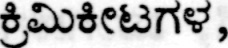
ಕ್ರಿಮಿಕೀಟಗಳ,
